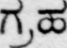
ಗ್ರಹ
